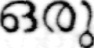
ഒരു
